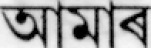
আমাৰ
